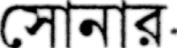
সোনার
